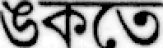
ঙকতে
